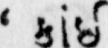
'કાંઈ
